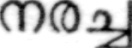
നരച്ച
